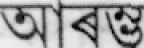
আৰম্ভ
